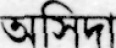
অসিদা
